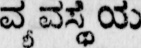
ವ್ಯವಸ್ಥೆಯ
